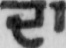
ਦਾ
